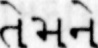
તેમને
